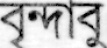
বৃন্দাবু
